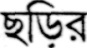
ছড়ির
